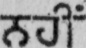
ਨਹੀਂ
